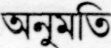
অনুমতি
